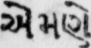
એમણે
